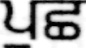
ਪੁਛ
